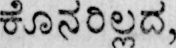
ಕೊನರಿಲ್ಲದ,
